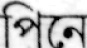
পিনে
